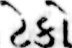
ટેકો
